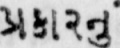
પ્રકારનું
